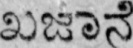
ಖಜಾನೆ
